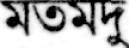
মতমদু
